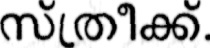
സ്ത്രീക്ക്.
